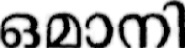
ഒമാനി
